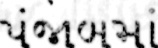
પંજાબમાં
